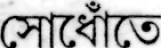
সোধোঁতে
